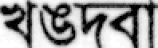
খঙদবা
